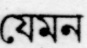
যেমন
